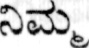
ನಿಮ್ಮ
